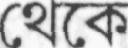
থেকে
